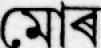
মোৰ
